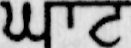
ਘਾਟ
